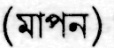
(মাপন)
